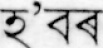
হ'বৰ
